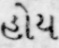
હોય
